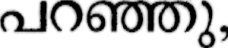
പറഞ്ഞു,
